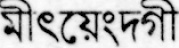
মীৎয়েংদগী
